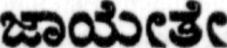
ಜಾಯೇತೇ
